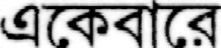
একেবারে
